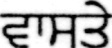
ਵਾਸਤੇ
